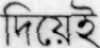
দিয়েই
